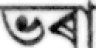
ভৰা
